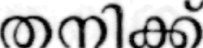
തനിക്ക്
